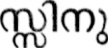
സ്സിനു
